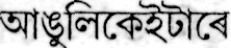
আঙুলিকেইটাৰে
